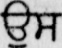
ਉਸ
